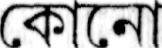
কোনো
